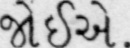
જોઈએ.
